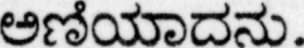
ಅಣಿಯಾದನು.
